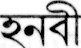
হনবী
